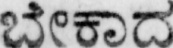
ಬೇಕಾದ
